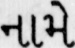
નામે
